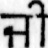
ਜੀ
